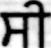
ਸੀ
